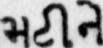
મટીને
